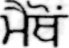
ਮੈਥੋਂ
